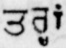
ਤਰ੍ਹਾਂ
